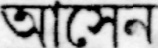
আসেন
